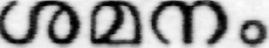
ശമനം
